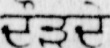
ਦੌੜਦੇ
